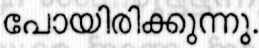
പോയിരിക്കുന്നു.
